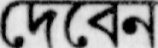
দেবেন
